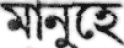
মানুহে
